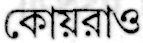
কোয়রাও
